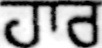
ਹਾਰ
